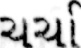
ચર્ચા
